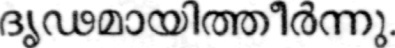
ദൃഢമായിത്തീര്‍ന്നു.
